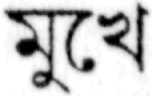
মুখে
